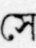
সে
